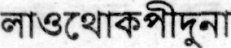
লাওথোকপীদুনা
